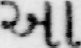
આ
